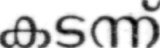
കടന്ന്
